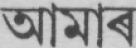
আমাৰ
